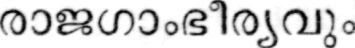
രാജഗാംഭീര്യവും
